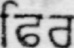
ਫਿਰ
